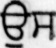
ਉਸ
